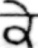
ਕੇ
